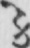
કે
